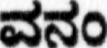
ವನಂ
